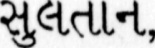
સુલતાન,
